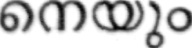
നെയും
